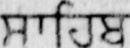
ਸਾਹਿਬ
